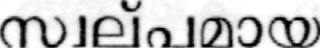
സ്വല്പമായ
